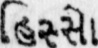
હિસ્સો
